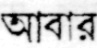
আবার
